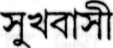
সুখবাসী
